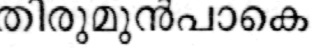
തിരുമുന്‍പാകെ
